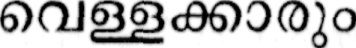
വെള്ളക്കാരും
